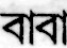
বাবা
